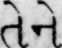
તેને
